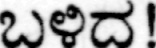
ಬಳಿದ!
